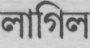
লাগিল
